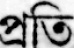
প্ৰতি
